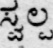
ಸ್ವಲ್ಪ
